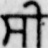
ਸੀ
